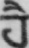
ਹੈ
